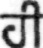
ਹੀ
